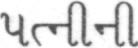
પત્નીની
